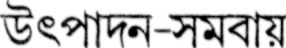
উৎপাদন-সমবায়
